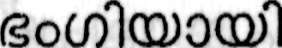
ഭംഗിയായി
